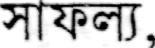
সাফল্য,
